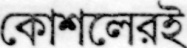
কোশলেরই
